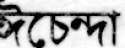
ঈচেন্দা
